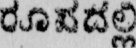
ರೂಪದಲ್ಲಿ
